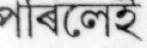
পৰিলেই
